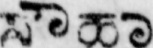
ಸೌಹಾ
